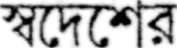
স্বদেশের
